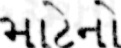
માટેનો
